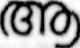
ആ
